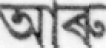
আৰু
